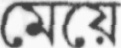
মেয়ে
